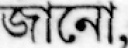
জানো,
